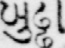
બુઢ્ઢા
